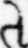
તે
